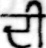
ਦੀ
